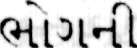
ભોગની
